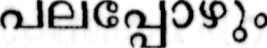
പലപ്പോഴും
